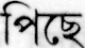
পিছে
